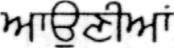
ਆਉਣੀਆਂ
